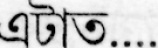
এটাত....
